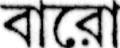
বারো
